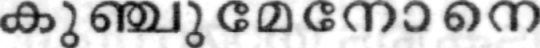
കുഞ്ചുമേനോനെ
